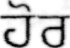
ਹੋਰ
